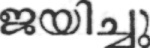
ജയിച്ചു
